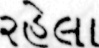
રહેલા
